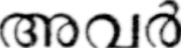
അവര്‍
